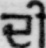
ਦੀ
